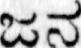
ಜನ
